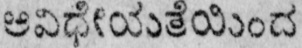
ಅವಿಧೇಯತೆಯಿಂದ
